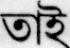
তাই
